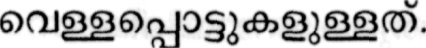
വെള്ളപ്പൊട്ടുകളുള്ളത്.
